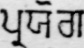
ਪ੍ਰਯੋਗ
